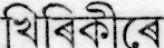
খিৰিকীৰে
